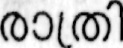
രാത്രി
